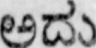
ಅದು
